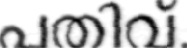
പതിവ്.
